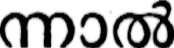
ന്നാല്‍
